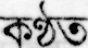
কণ্ঠত
